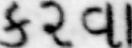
કરવા
